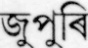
জুপুৰি
